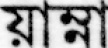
য়াম্না
